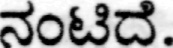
ನಂಟಿದೆ.
